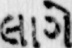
લાગે
